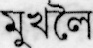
মুখলৈ
